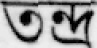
তন্দ্র
